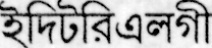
ইদিটরিএলগী
